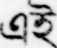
এই
